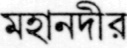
মহানদীর
